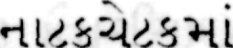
નાટકચેટકમાં
